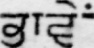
ਭਾਵੇਂ
